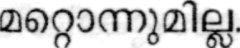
മറ്റൊന്നുമില്ല.
